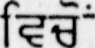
ਵਿਚੋਂ
